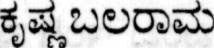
ಕೃಷ್ಣಬಲರಾಮ
